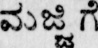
ಮಜ್ಜಿಗೆ
